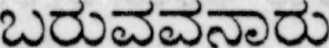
ಬರುವವನಾರು
